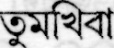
তুমখিবা
